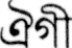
ঐগী
